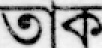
তাক
